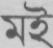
মই
